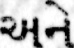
અને
